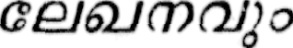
ലേഖനവും
